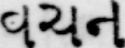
વચન
